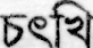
চৎখি
